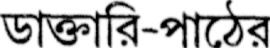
ডাক্তারি-পাঠের
